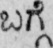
ಬಗ್ಗೆ
